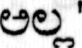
ಅಲ್ಲ
